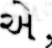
એ,
